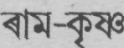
ৰাম-কৃষ্ণ
